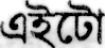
এইটো
